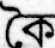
কৈ
